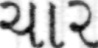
ચાર
